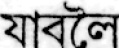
যাবলৈ
